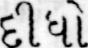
દીધો
